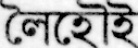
লৈহৌই
